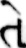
તે
